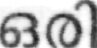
ഒരി
